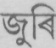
জুৰি
